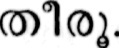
തീരൂ.
